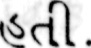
હતી.
